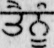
ਤੈਨੂੰ
